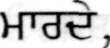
ਮਾਰਦੇ,
